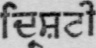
ਦ੍ਰਿਸ਼ਟੀ
